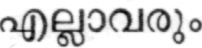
എല്ലാവരും
